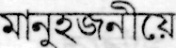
মানুহজনীয়ে
